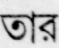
তার
